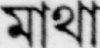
মাথা
